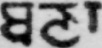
ਬਣਾ
